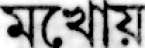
মখোয়
